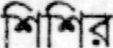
শিশির
